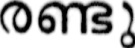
രണ്ടു
